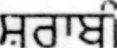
ਸ਼ਰਾਬੀ
